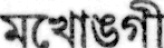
মখোঙগী
